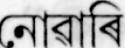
নোৱাৰি
